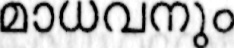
മാധവനും
